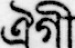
ঐগী
